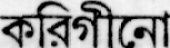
করিগীনো
